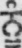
ਨੂੰ
